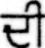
ਦੀ
